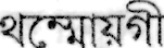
থম্মোয়গী
